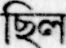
ছিল
